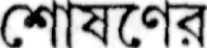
শোষণের
